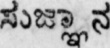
ಸುಜ್ಞಾನ
